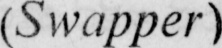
(Swapper)
